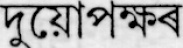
দুয়োপক্ষৰ
